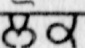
ਲੋਕ
